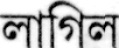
লাগিল
